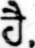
ਹੈ,
